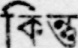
কিন্তু
